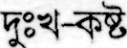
দুঃখ-কষ্ট
